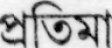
প্রতিমা
